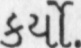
કર્યો.
